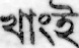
খাংই
